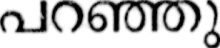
പറഞ്ഞു
